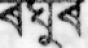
ৰঘুৰ
